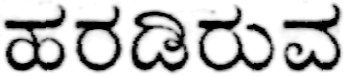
ಹರಡಿರುವ
